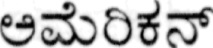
ಅಮೆರಿಕನ್
